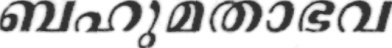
ബഹുമതാഭവ
